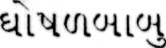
ઘોષળબાબુ
